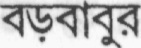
বড়বাবুর
